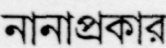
নানাপ্রকার
